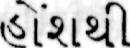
હોંશથી
